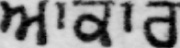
ਆਕਾਰ
